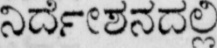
ನಿರ್ದೇಶನದಲ್ಲಿ
